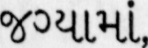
જગ્યામાં,
